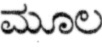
ಮೂಲ
